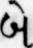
બે
